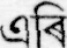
এৰি
